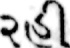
રહી
